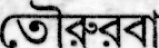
তৌরুরবা
